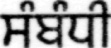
ਸੰਬੰਧੀ
